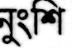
নুংশি
